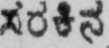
ಸರಕಿನ
